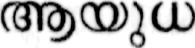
ആയുധ
